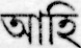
আহি
